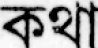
কথা
